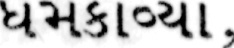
ધમકાવ્યા,
